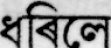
ধৰিলে
